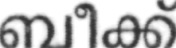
ബീക്ക്
